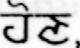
ਹੋਣ,
